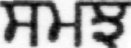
ਸਮਝ
